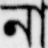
না
